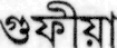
গুফীয়া
